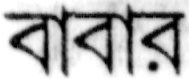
বাবার
